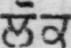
ਲੋਕ
